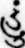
હું
